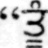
''ਤੂੰ
